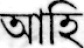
আহি
